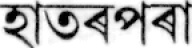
হাতৰপৰা
